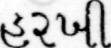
હરખી
